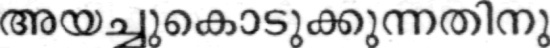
അയച്ചുകൊടുക്കുന്നതിനു
